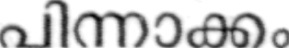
പിന്നാക്കം
